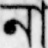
না
